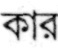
কার
